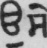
ਉਸੇ
